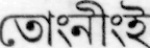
তোংনীংই
